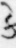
કે
